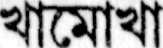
খামোখা
